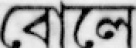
বোলে
